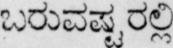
ಬರುವಷ್ಟರಲ್ಲಿ
